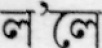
ল'লে
